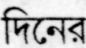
দিনের
